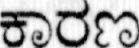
ಕಾರಣ
